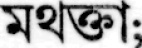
মথক্তা;
